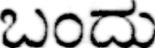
ಬಂದು
